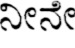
ನೀನೇ
